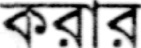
করার
